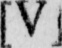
[V]
